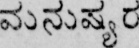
ಮನುಷ್ಯರ
